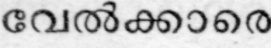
വേല്‍ക്കാരെ
